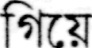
গিয়ে
